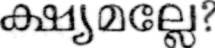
ക്ഷ്യമല്ലേ?
